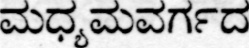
ಮಧ್ಯಮವರ್ಗದ
